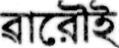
ৱারৌই
